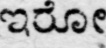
ಇರೋ
